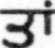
ਤਾਂ
